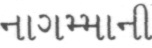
નાગમ્માની
